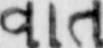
વાત
